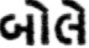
બોલે
